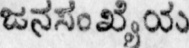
ಜನಸಂಖ್ಯೆಯ
